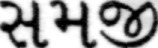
સમજી
